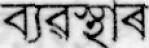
ব্যৱস্থাৰ
